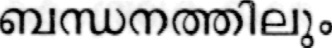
ബന്ധനത്തിലും
